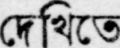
দেখিতে
